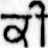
ਕੀ
